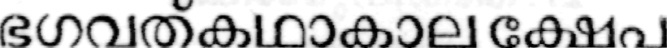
ഭഗവത്കഥാകാലക്ഷേപ
